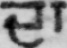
ਦਾ
